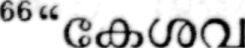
66"കേശവ
